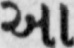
આ
